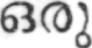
ഒരു
